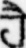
ਹੈ
